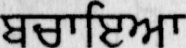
ਬਚਾਇਆ
